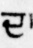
ਦਾ
